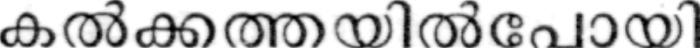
കല്‍ക്കത്തയില്‍പോയി
